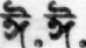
ঈ.ঈ.
